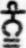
ਨੂੰ
